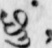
છું,
